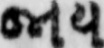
જાય
